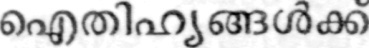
ഐതിഹ്യങ്ങള്‍ക്ക്
